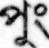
পুং
